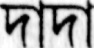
দাদা
